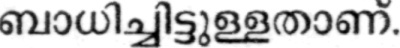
ബാധിച്ചിട്ടുള്ളതാണ്.
